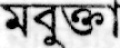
মবুক্তা
